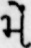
મેં
